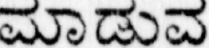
ಮಾಡುವ
